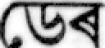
ডেৰ
